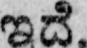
ಇದೆ.
